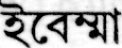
ইবেম্মা
